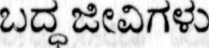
ಬದ್ಧಜೀವಿಗಳು
